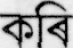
কৰি
